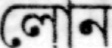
লোন
